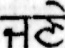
ਜਣੇ
